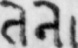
તેનો
